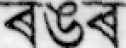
ৰঙৰ
